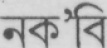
নক'বি
